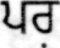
ਪਰ
